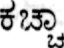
ಕಚ್ಚಾ
